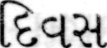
દિવસ
